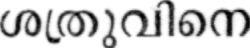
ശത്രുവിനെ
